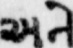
અને
